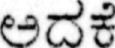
ಅದಕೆ
